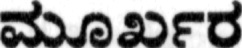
ಮೂರ್ಖರ
